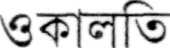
ওকালতি
